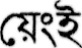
য়েংই
